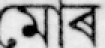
মোৰ
